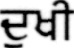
ਦੁਖੀ
